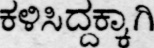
ಕಳಿಸಿದ್ದಕ್ಕಾಗಿ
